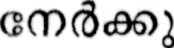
നേര്‍ക്കു
